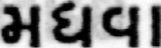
મધવા
